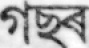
গছৰ
